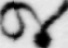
જ
